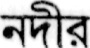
নদীর
